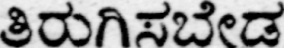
ತಿರುಗಿಸಬೇಡ
